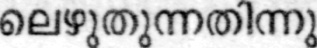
ലെഴുതുന്നതിന്നു
